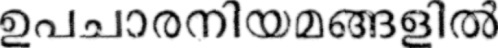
ഉപചാരനിയമങ്ങളില്‍
